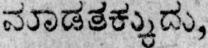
ಮಾಡತಕ್ಕುದು,
